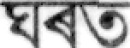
ঘৰত
